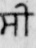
ਸੀ
